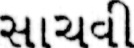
સાચવી
